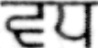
ਵਧ
